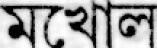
মখোল
